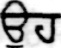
ਉਹ
